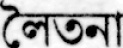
লৈতনা
